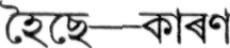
হৈছে-কাৰণ
